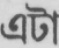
এটা
